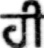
ਹੀ
